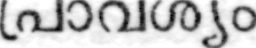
പ്രാവശ്യം
